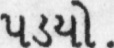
પડયો.
